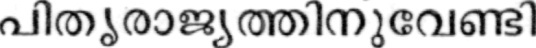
പിതൃരാജ്യത്തിനുവേണ്ടി
